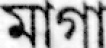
মাগা
